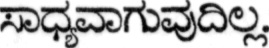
ಸಾಧ್ಯವಾಗುವುದಿಲ್ಲ.
